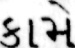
કામે
